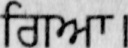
ਗਿਆ।
